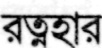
রত্নহার
